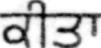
ਕੀਤਾ
